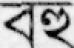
বহু
